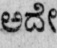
ಅದೇ
